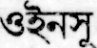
ওইনসু
